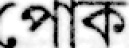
পোক
